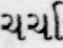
ચર્ચા
